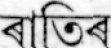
ৰাতিৰ
